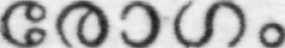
രോഗം
